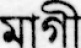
মাগী
